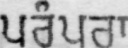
ਪਰੰਪਰਾ
